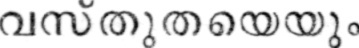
വസ്തുതയെയും
